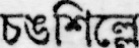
চঙশিল্লে
